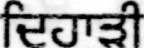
ਦਿਹਾੜੀ
